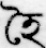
হৈ
